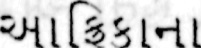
આફ્રિકાના
